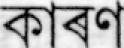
কাৰণ
